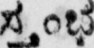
ಸ್ತಂಭ
